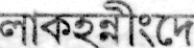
লাকহন্নীংদে
